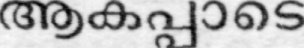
ആകപ്പാടെ
